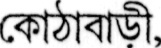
কোঠাবাড়ী,
